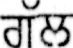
ਗੱਲ
